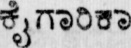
ಕೈಗಾರಿಕಾ
